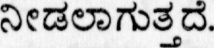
ನೀದಲಾಗುತ್ತದೆ.
